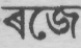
ৰজে
